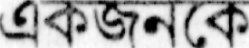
একজনকে
